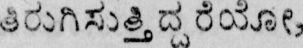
ತಿರುಗಿಸುತ್ತಿದ್ದರೆಯೋ,
